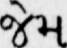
જેમ
